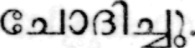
ചോദിച്ചു.
